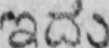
ಇದು
